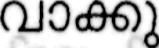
വാക്കു
